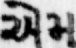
એમ
